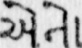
એનો
